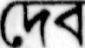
দেব
